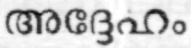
അദ്ദേഹം
